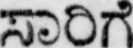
ಸಾರಿಗೆ
